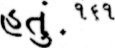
હતું.૧૬૧
